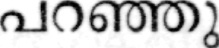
പറഞ്ഞു
